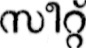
സീറ്റ്
